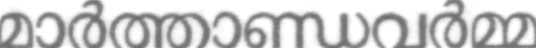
മാര്‍ത്താണ്ഡവര്‍മ്മ
